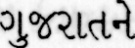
ગુજરાતને
